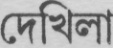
দেখিলা
